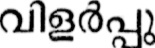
വിളര്‍പ്പു
